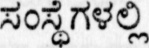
ಸಂಸ್ಥೆಗಳಲ್ಲಿ
